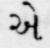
એ
